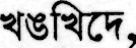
খঙখিদে,
